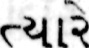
ત્યારે
